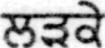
ਲੜਕੇ
